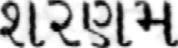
શરણમ
